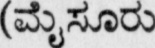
(ಮೈಸೂರು
